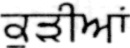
ਕੁੜੀਆਂ
